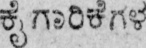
ಕೈಗಾರಿಕೆಗಳ
